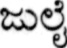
ಜುಲೈ
